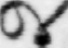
જ
